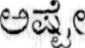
ಅಷ್ಟೇ
